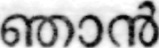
ഞാന്‍
